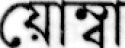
য়োম্বা
